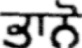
ਭਾਨੋ
